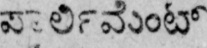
ಪಾರ್ಲಿಮೆಂಟ್
